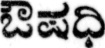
ಔಷಧಿ
